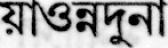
য়াওন্নদুনা
